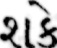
શકે
